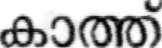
കാത്ത്
